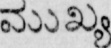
ಮುಖ್ಯ
